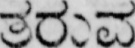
ತರುವ
